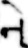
ને
